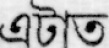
এটাত
